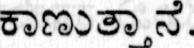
ಕಾಣುತ್ತಾನೆ.
